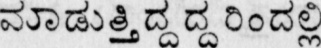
ಮಾಡುತ್ತಿದ್ದದ್ದರಿಂದಲ್ಲಿ
